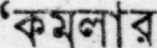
‘কমলার
